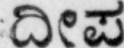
ದೀಪ
